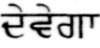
ਦੇਵੇਗਾ
